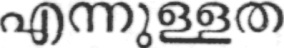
എന്നുള്ളത
